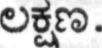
ಲಕ್ಷಣ.
